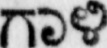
ಗಾಳಿ
